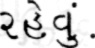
રહેવું.
